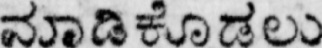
ಮಾಡಿಕೊಡಲು
